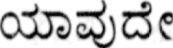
ಯಾವುದೇ
